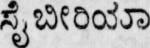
ಸೈಬೀರಿಯಾ
